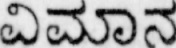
ವಿಮಾನ
